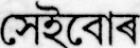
সেইবোৰ
